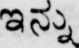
ಇನ್ನು
